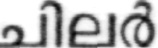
ചിലര്‍
